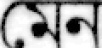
মেন
